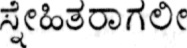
ಸ್ನೇಹಿತರಾಗಲೀ
